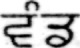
ਵੰਡ
